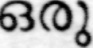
ഒരു
